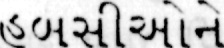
હબસીઓને
